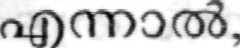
എന്നാല്‍,
